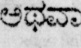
ಅಥವಾ
